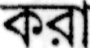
করা
